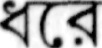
ধরে
